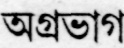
অগ্রভাগ
